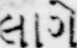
લાગે
